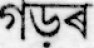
গড়ৰ
